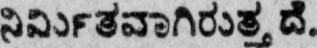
ನಿರ್ಮಿತವಾಗಿರುತ್ತದೆ.
